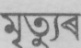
মৃত্যুৰ
